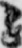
કે
